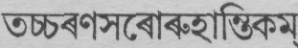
তচ্চৰণসৰোৰুহান্তিকম্
